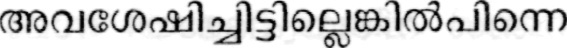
അവശേഷിച്ചിട്ടില്ലെങ്കില്‍പിന്നെ
